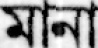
মানা
